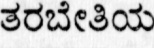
ತರಬೇತಿಯ
